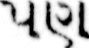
પણ
